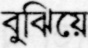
বুঝিয়ে
